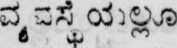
ವ್ಯವಸ್ಥೆಯಲ್ಲೂ
